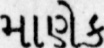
માણેક
